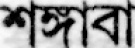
শঙ্গাবা
